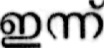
ഇന്ന്
